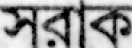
সরাক
